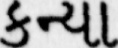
કન્યા
